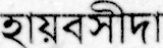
হায়বসীদা
